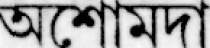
অশোমদা
